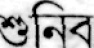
শুনিব
